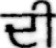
ਦੀ
